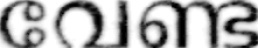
വേണ്ട
